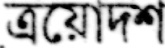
ত্রয়োদশ
